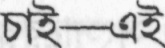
চাই–এই
